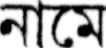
নামে
